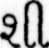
શી
